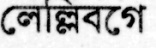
লেল্লিবগে
